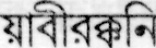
য়াবীরক্কনি
